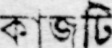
কাজটি
